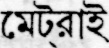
মেট্‌রাই
